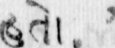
હતો.'
